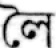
লৈ
